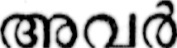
അവര്‍
